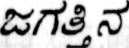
ಜಗತ್ತಿನ
